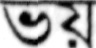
ভয়
